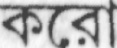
করো
